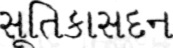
સૂતિકાદન
